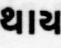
થાય
